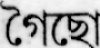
গৈছো
